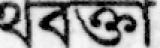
থবক্তা
